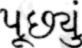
પૂછ્યું
